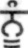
ਨੂੰ
